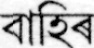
বাহিৰ
